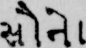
સૌનો
